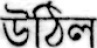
উঠিল
